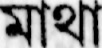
মাথা
